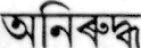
অনিৰুদ্ধ
